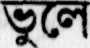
ভুলে
